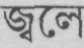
জ্বলে
